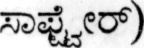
ಸಾಫ್ಟ್ವೇರ್)
